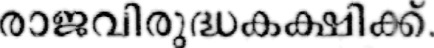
രാജവിരുദ്ധകക്ഷിക്ക്.
